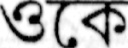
ওকে
